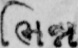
ભિન્ન
